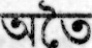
অতৈ
